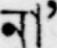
না’
